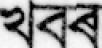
খবৰ
